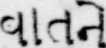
વાતને
